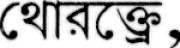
থোরক্ত্রে,
